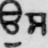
ਉਸ
